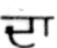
ਦਾ
